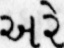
અરે
